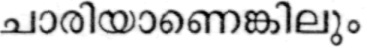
ചാരിയാണെങ്കിലും
